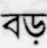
বড়
